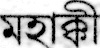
মহাক্কী
